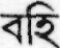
বহি
